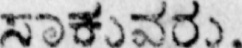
ಸಾಕುವರು.
